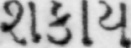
શકાય
